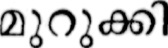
മുറുക്കി
